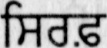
ਸਿਰਫ਼
